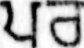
ਪਰ
